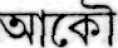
আকৌ
